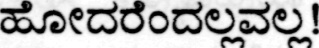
ಹೋದರೆಂದಲ್ಲವಲ್ಲ!
